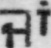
ਜਾਂ
